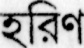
হরিণ
